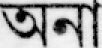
অনা
